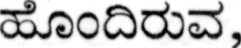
ಹೊಂದಿರುವ,
